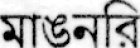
মাঙনরি
